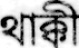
থাক্কী
